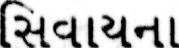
સિવાયના
